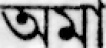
অমা
